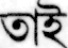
তাই
